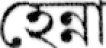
হেন্না
